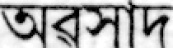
অৱসাদ
